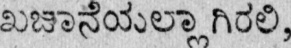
ಖಜಾನೆಯಲ್ಲಾಗಿರಲಿ,
